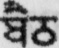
ਬੈਠ
